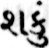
શકું
